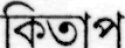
কিতাপ
